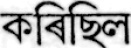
কৰিছিল
